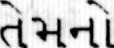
તેમનો
